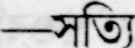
–সত্যি
